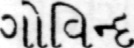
ગોવિન્દ
